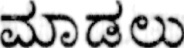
ಮಾಡಲು
